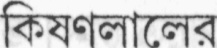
কিষণলালের
